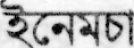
ইনেমচা
